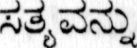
ಸತ್ಯವನ್ನು
